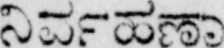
ನಿರ್ವಹಣಾ
